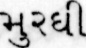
મુરઘી
